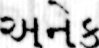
અનેક
